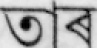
তাৰ
